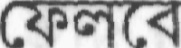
ফেলবে
